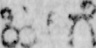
ಹೀಗೆ
